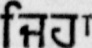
ਜਿਹਾ
